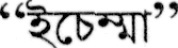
“ইচেম্মা”
